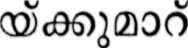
യ്ക്കുമാറ്
